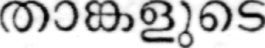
താങ്കളുടെ
